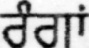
ਰੰਗਾਂ
